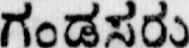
ಗಂಡಸರು
